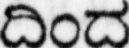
ದಿಂದ
